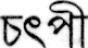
চৎপী
